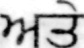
ਅਤੇ
